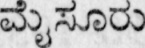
ಮೈಸೂರು
